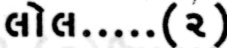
લોલ......(૨)
